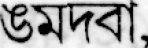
ঙমদবা,
